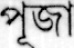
পূজা
